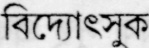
বিদ্যোত্সুক
